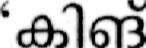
‘കിങ്
